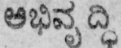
ಅಭಿವೃದ್ಧಿ
